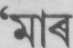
'মাৰ
